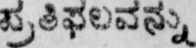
ಪ್ರತಿಫಲವನ್ನು
